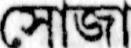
সোজা
